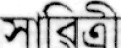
সাৱিত্রী
